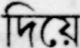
দিয়ে
